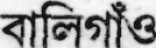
বালিগাঁও
